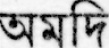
অমদি
